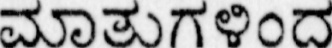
ಮಾತುಗಳಿಂದ
